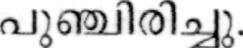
പുഞ്ചിരിച്ചു.
